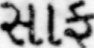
સાફ
